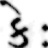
કેઃ
